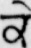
ਕੇ
